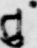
તું
